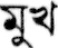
মুখ
